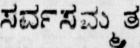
ಸರ್ವಸಮ್ಮತ
